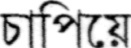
চাপিয়ে
